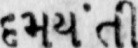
દમયંતી
